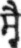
ਸ੍ਵੈ
